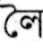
লৈ
